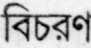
বিচরণ
